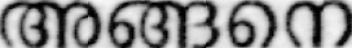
അങ്ങനെ
